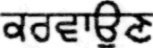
ਕਰਵਾਉਣ
